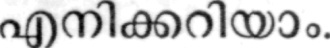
എനിക്കറിയാം.
